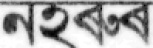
নহৰুৰ
